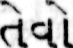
તેવો
